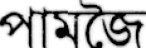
পামজৈ
